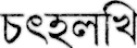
চৎহলখি
